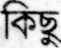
কিছু
